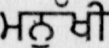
ਮਨੁੱਖੀ
